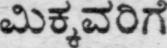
ಮಿಕ್ಕವರಿಗೆ
